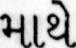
માથે
